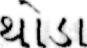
થોડા
